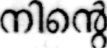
നിന്റെ
